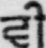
ਵੀ
